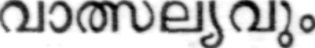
വാത്സല്യവും
